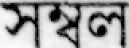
সম্বল
